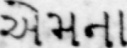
એમના
